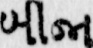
બીજા
